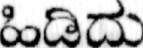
ಹಿಡಿದು
